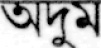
অদুম
